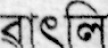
ৱাৎলি
